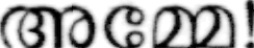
അമ്മേ!
